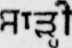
ਸਾੜ੍ਹੀ
